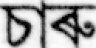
চাৰু
